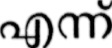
എന്ന്
